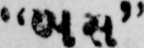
“બસ"
